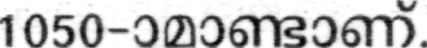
1050-ാമാണ്ടാണ്.
